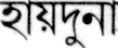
হায়দুনা
